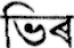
ভিৰ
